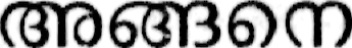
അങ്ങനെ
